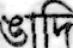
ঙাদি
